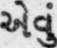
એવું
